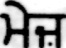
ਮੇਜ਼
